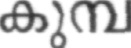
കുമ്പ
